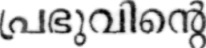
പ്രഭുവിന്റെ
